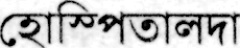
হোস্পিতালদা
